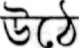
উঠে
